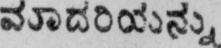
ಮಾದರಿಯನ್ನು
